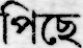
পিছে
